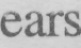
ears
